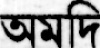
অমদি
